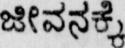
ಜೀವನಕ್ಕೆ
